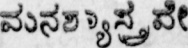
ಮನಶ್ಯಾಸ್ತ್ರವೇ
